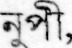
নুপী,
